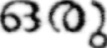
ഒരു
